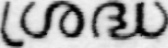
ശ്രദ്ധ
